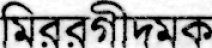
মিররগীদমক
